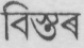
বিস্তৰ
